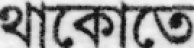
থাকোতে
